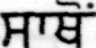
ਸਾਥੋਂ
